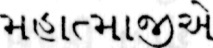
મહાત્માજીએ
